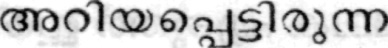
അറിയപ്പെട്ടിരുന്ന
